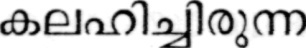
കലഹിച്ചിരുന്ന
